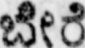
ಬೇರೆ
